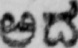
ಅದ
